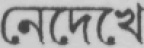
নেদেখে
